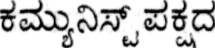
ಕಮ್ಯುನಿಸ್ಟ್ ಪಕ್ಷದ
